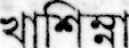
খাশিম্না
